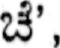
ಚೆ',
